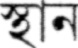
স্থান
